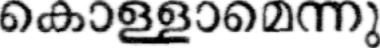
കൊള്ളാമെന്നു
